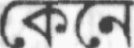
কেনে
